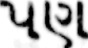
પણ
